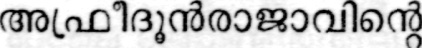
അഫ്രീദൂന്‍രാജാവിന്റെ
